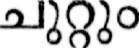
ചുറ്റും
